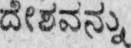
ದೇಶವನ್ನು
